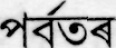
পর্বতৰ
